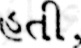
હતી,
